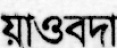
য়াওবদা
